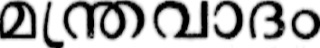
മന്ത്രവാദം
